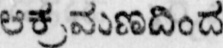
ಆಕ್ರಮಣದಿಂದ
